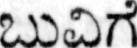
ಬುವಿಗೆ
